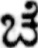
ಚೆ
